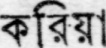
করিয়া
